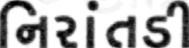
નિરાંતડી
